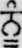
ਨੂੰ
